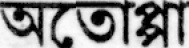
অতোপ্পা
